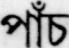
পাঁচ
